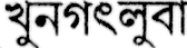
খুনগৎলুবা
